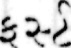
ફર્સ્ટ
